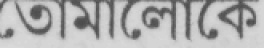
তোমালোকে
